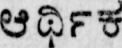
ಆರ್ಥಿಕ
